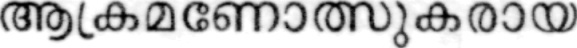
ആക്രമണോത്സുകരായ
